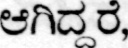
ಆಗಿದ್ದರೆ,
